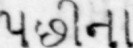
પછીના
